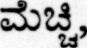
ಮೆಚ್ಚಿ,
